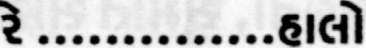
રે.............હાલો
